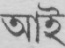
আই
